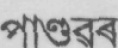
পাণ্ডৱৰ
